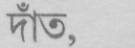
দাঁত,
